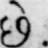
છે.
